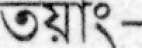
তয়াং-
